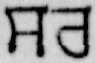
ਸਰ
